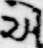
એ
